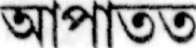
আপাতত
